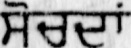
ਸੋਚਦਾਂ
